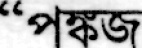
“পঙ্কজ
